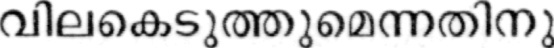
വിലകെടുത്തുമെന്നതിനു
